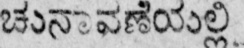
ಚುನಾವಣೆಯಲ್ಲಿ
